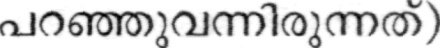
പറഞ്ഞുവന്നിരുന്നത്)
